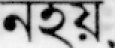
নহয়,
